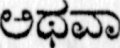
ಅಥವಾ
